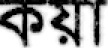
কয়া
